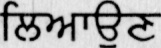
ਲਿਆਉਣ
